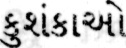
કુશંકાઓ
